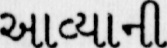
આવ્યાની
